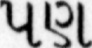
પણ
